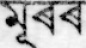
মূৰৰ
